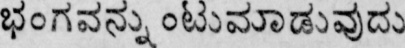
ಭಂಗವನ್ನುಂಟುಮಾಡುವುದು
